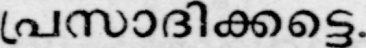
പ്രസാദിക്കട്ടെ.
